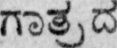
ಗಾತ್ರದ
